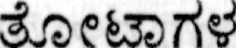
ತೋಟಾಗಳ
